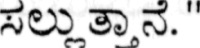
ಸಲ್ಲುತ್ತಾನೆ."
